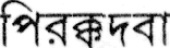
পিরক্কদবা
